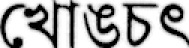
খোঙচৎ
